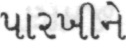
પારખીને
